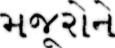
મજૂરોને
